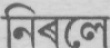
নিৰলে
